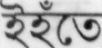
ইহঁতে
